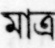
মাত্র
